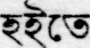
হইতে
